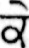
ਕੇ
